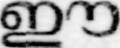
ഈ
